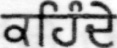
ਕਹਿੰਦੇ
